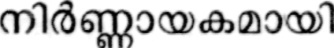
നിര്‍ണ്ണായകമായി
